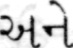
અને
